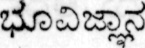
ಭೂವಿಜ್ಞಾನ
